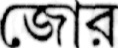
জোর
